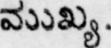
ಮುಖ್ಯ.
